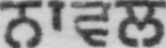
ਨਾਵਲ
